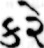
કરે
